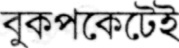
বুকপকেটেই
